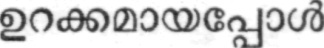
ഉറക്കമായപ്പോള്‍
